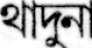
থাদুনা
